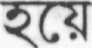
হয়ে
